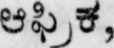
ಆಫ್ರಿಕ,
